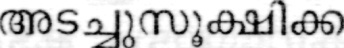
അടച്ചുസൂക്ഷിക്ക
